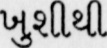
ખુશીથી
